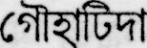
গৌহাটিদা
